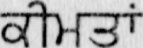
ਕੀਮਤਾਂ
